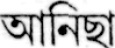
আনিছা
